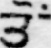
ਤੋਂ
